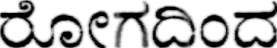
ರೋಗದಿಂದ
